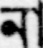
না
